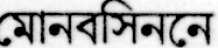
মোনবসিননে
